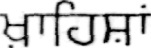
ਖ਼ਾਹਿਸ਼ਾਂ
